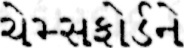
ચેમ્સફોર્ડને
